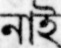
নাই
